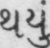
થયું
